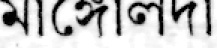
মাঙ্গোলদা
